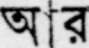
আর
